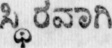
ಸ್ಥಿರವಾಗಿ
